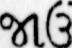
જાઉં
